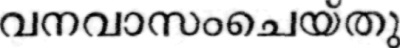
വനവാസംചെയ്തു
